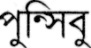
পুন্সিবু
